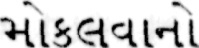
મોકલવાનો
